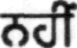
ਨਹੀਂ
